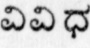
ವಿವಿಧ
